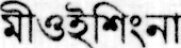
মীওইশিংনা
